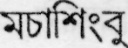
মচাশিংবু
